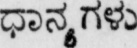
ಧಾನ್ಯಗಳು
